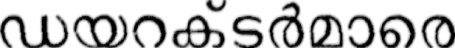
ഡയറക്ടര്‍മാരെ
